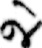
જે
